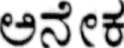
ಅನೇಕ
